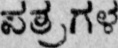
ಪತ್ರಗಳ
